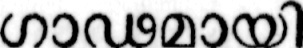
ഗാഢമായി
